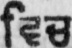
ਵਿਚ
